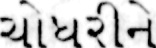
ચોધરીને
